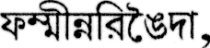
ফম্মীন্নরিঙৈদা,
